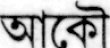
আকৌ
